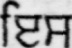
ਇਸ
